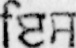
ਇਸ
